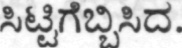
ಸಿಟ್ಟಿಗೆಬ್ಬಿಸಿದ.
